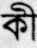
কী
